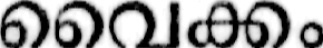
വൈക്കം
